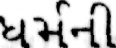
ધર્મની
